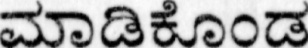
ಮಾಡಿಕೊಂಡ
